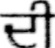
ਦੀ
